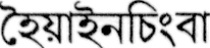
হৈয়াইনচিংবা
